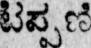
ಟಿಪ್ಪಣಿ
